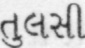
તુલસી
